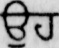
ਉਹ
